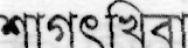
শাগৎখিবা
